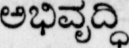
ಅಭಿವೃದ್ಧಿ
